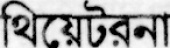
থিয়েটরনা
